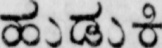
ಹುಡುಕಿ
